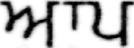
ਆਪ
